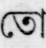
তো
